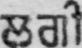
ਲਗੀ
